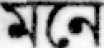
মনে
